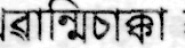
থৱান্মিচাক্কা
